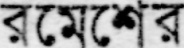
রমেশের
